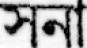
সনা
